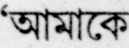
‘আমাকে
